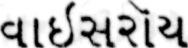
વાઇસરૉય
